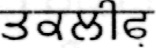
ਤਕਲੀਫ਼
